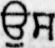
ਉਸ
